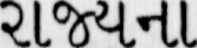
રાજ્યના
